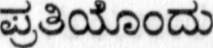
ಪ್ರತಿಯೊಂದು
